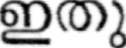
ഇതു
